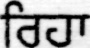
ਰਿਹਾ
